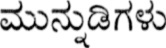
ಮುನ್ನುಡಿಗಳು
